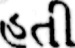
હતી
